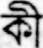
কী
